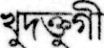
খুদক্তুগী
